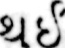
થઈ
